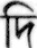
দি
